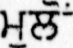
ਮੁਲੋਂ
